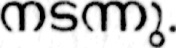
നടന്നു.
